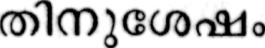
തിനുശേഷം
